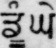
ਡੂੰਘੇ
